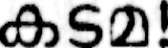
കടമ!
